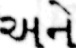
અને
